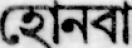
হোনবা
